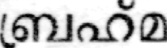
ബ്രഹ്മ
